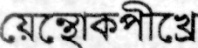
য়েন্থোকপীখ্রে
